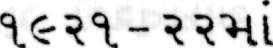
૧૯૨૧-૨૨માં
